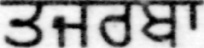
ਤਜਰਬਾ
